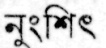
নুংশিৎ
